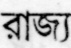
রাজ্য
